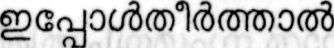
ഇപ്പോള്‍തീര്‍ത്താല്‍
